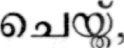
ചെയ്ത്,
